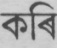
কৰি
